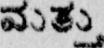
ಮತ್ತು
